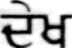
ਦੇਖ
